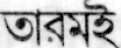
তারমই
